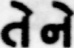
તેને
